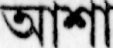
আশা
